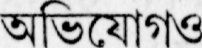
অভিযোগও
